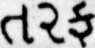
તરફ
